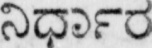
ನಿರ್ಧಾರ
